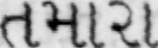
તમારા
